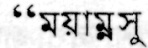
“ময়াম্নসু
